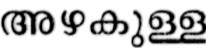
അഴകുള്ള
